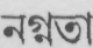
নগ্নতা
